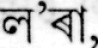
ল'ৰা,
